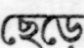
ছেড়ে
